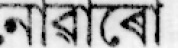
নোৱাৰো
